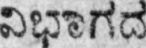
ವಿಭಾಗದ
